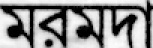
মরমদা
